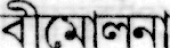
বীমোলনা
